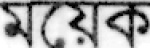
ময়েক
